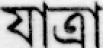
যাত্রা
